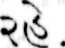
રહે.
